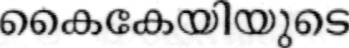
കൈകേയിയുടെ
